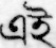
এই
